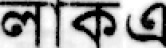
লাকএ
